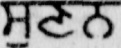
ਸੁਣਨ
